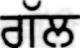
ਗੱਲ
